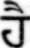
ਹੈ
